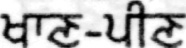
ਖਾਣ-ਪੀਣ
